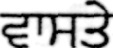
ਵਾਸਤੇ
